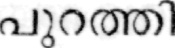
പുറത്തി
